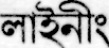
লাইনীং
